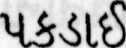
પકડાઈ
